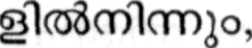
ളില്‍നിന്നും,
